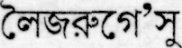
লৈজরুগে’সু
